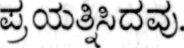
ಪ್ರಯತ್ನಿಸಿದವು.
